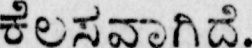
ಕೆಲಸವಾಗಿದೆ.
